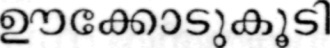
ഊക്കോടുകൂടി
